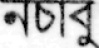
নচাবু
